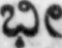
ಭೀ
